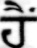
ਹੈ
